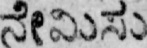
ನೇಮಿಸು
